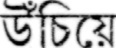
উঁচিয়ে
